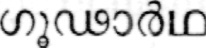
ഗൂഢാര്‍ഥ
